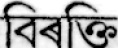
বিৰক্তি
